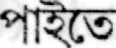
পাইতে
